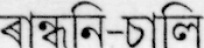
ৰান্ধনি-চালি
